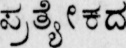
ಪ್ರತ್ಯೇಕದ
